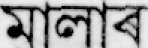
মালাৰ
